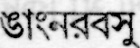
ঙাংনরবসু
